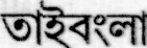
তাইবংলা
